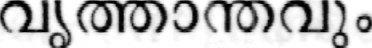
വൃത്താന്തവും
